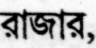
রাজার,
